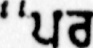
''ਪਰ
